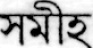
সমীহ
